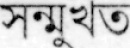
সন্মুখত
